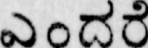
ಎಂದರೆ
